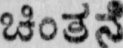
ಚಿಂತನೆ
